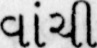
વાંચી
